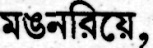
মঙনরিয়ে,
